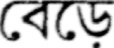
বেড়ে
